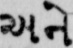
અને
